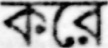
করে
